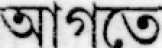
আগতে
